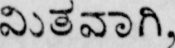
ಮಿತವಾಗಿ,
